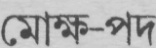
মোক্ষ-পদ
